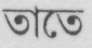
তাতে
